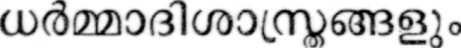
ധര്‍മ്മാദിശാസ്ത്രങ്ങളും
